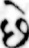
છે
